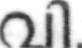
വി.
